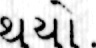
થયો.
